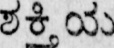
ಶಕ್ತಿಯ
